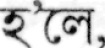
হ'লে,
